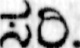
ಸರಿ.
